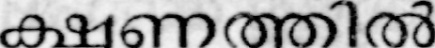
ക്ഷണത്തില്‍
